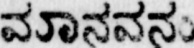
ಮಾನವನು
